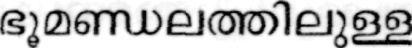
ഭൂമണ്ഡലത്തിലുള്ള
